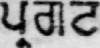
ਪ੍ਰਗਟ
